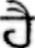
ਹੈ
